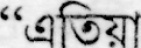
"এতিয়া
